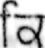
ਕਿ
